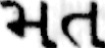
મત
